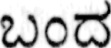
ಬಂದ
